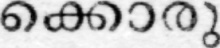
ക്കൊരു
